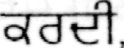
ਕਰਦੀ,
